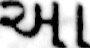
આ
